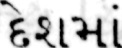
દેશમાં
